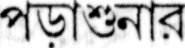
পড়াশুনার
